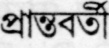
প্রান্তবর্তী
